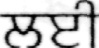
ਲਈ
